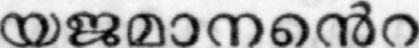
യജമാനന്റെ
